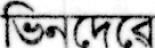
ভিনদেৱে
